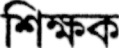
শিক্ষক
